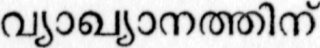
വ്യാഖ്യാനത്തിന്
